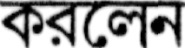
করলেন
